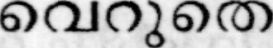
വെറുതെ
